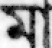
মা
